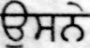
ਉਸਨੇ
